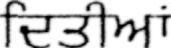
ਦਿਤੀਆਂ
